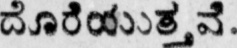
ದೊರೆಯುತ್ತವೆ.
